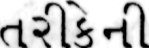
તરીકેની
